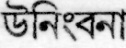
উনিংবনা
